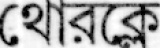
থোরক্লে
